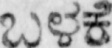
ಬಳಕೆ
